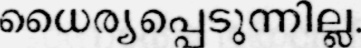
ധൈര്യപ്പെടുന്നില്ല.
